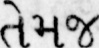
તેમજ
